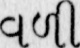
વળી
